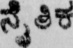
ನೈತಿಕ
